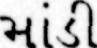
માંડી
